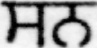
ਸਨ
